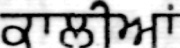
ਕਾਲੀਆਂ
